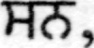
ਸਨ,
